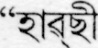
"হাৱ্‌ছী
